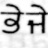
ਭੇਜੇ
